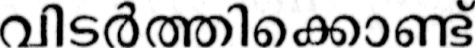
വിടര്‍ത്തിക്കൊണ്ട്
